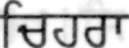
ਚਿਹਰਾ
